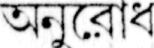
অনুরোধ
